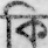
কি
